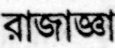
রাজাজ্ঞা
